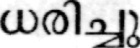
ധരിച്ചു
